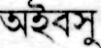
অইবসু
